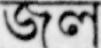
জল
